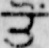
ਤੋਂ
